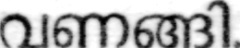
വണങ്ങി.
